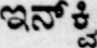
ಇನ್‌ಕ್ವಿ
